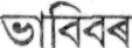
ভাবিবৰ
